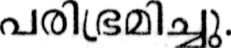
പരിഭ്രമിച്ചു.
